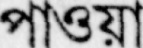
পাওয়া
